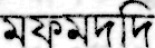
মফমদদি
